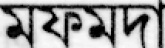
মফমদা
